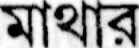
মাথার
